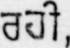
ਰਹੀ,
